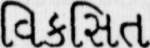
વિકસિત
